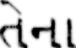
તેના
